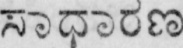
ಸಾಧಾರಣ
